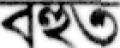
বহুত
